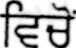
ਵਿਚੋਂ
